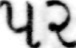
પર
